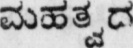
ಮಹತ್ವದ
